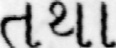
તથા
